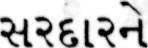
સરદારને
